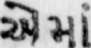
એમાં
